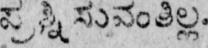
ಪ್ರಶ್ನಿಸುವಂತಿಲ್ಲ.
